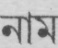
নাম
